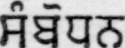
ਸੰਬੋਧਨ
